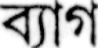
ব্যাগ
